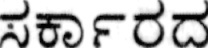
ಸರ್ಕಾರದ
